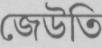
জেউতি
